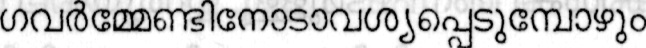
ഗവര്‍മ്മേണ്ടിനോടാവശ്യപ്പെടുമ്പോഴും
